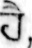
ਹੈ,
